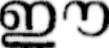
ഈ
